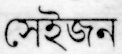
সেইজন
